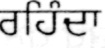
ਰਹਿੰਦਾ
